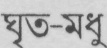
ঘৃত-মধু
